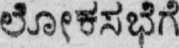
ಲೋಕಸಭೆಗೆ
